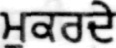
ਮੁਕਰਦੇ
